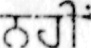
ਨਹੀਂ
